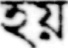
হয়
